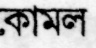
কোমল
